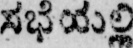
ಸಭೆಯಲ್ಲಿ
